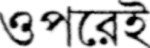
ওপরেই
